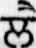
ਲੈ
